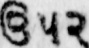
ઉપર
